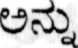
ಅನ್ನು
